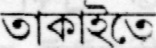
তাকাইতে
